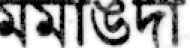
মমাঙদা
